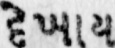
દેખાય
